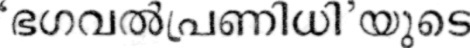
'ഭഗവല്‍പ്രണിധി'യുടെ
